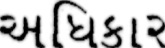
અધિકાર
